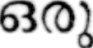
ഒരു
